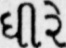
ધીરે
